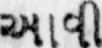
આવી
